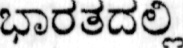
ಭಾರತದಲ್ಲಿ
